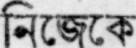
নিজেকে
